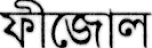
ফীজোল
